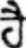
ਹੈ'
